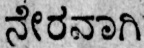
ನೇರವಾಗಿ
